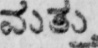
ಮತ್ತು
